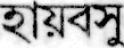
হায়বসু
